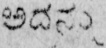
ಅದನ್ನು
